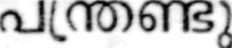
പന്ത്രണ്ടു
